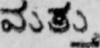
ಮತ್ತು
